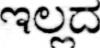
ಇಲ್ಲದ
